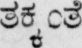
ತಕ್ಕಂತೆ
